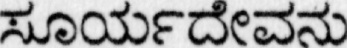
ಸೂರ್ಯದೇವನು
